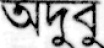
অদুবু
